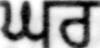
ਘਰ
